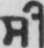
ਸੀ
